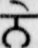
ਨੇ
